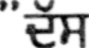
''ਦੱਸ
